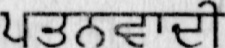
ਪਤਨਵਾਦੀ
